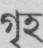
গৃহ
